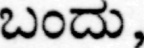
ಬಂದು,
